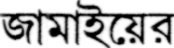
জামাইয়ের
